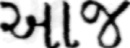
આજ
